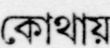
কোথায়
